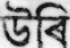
উৰি
